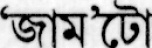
'জাম'টো
